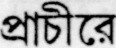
প্রাচীরে
